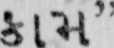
કામ”
